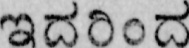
ಇದರಿಂದ
